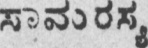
ಸಾಮರಸ್ಯ
